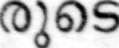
രുടെ
